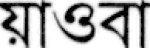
য়াওবা
